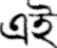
এই
